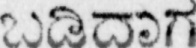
ಬಡಿದಾಗ
